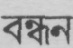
বন্ধন
